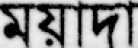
ময়াদা
